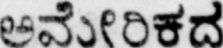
ಅಮೇರಿಕದ
